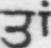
ਤਾਂ
